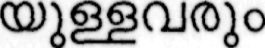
യുള്ളവരും
